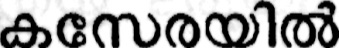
കസേരയില്‍
